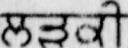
ਲੜਕੀ
